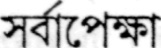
সর্বাপেক্ষা
